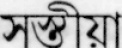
সস্তীয়া
